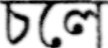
চলে
